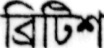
ব্রিটিশ
